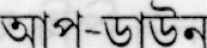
আপ-ডাউন
